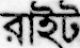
রাইট
